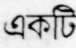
একটি
